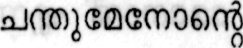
ചന്തുമേനോന്റെ
